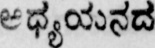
ಅಧ್ಯಯನದ
